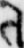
તે
